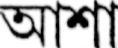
আশা
